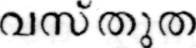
വസ്തുത
